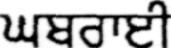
ਘਬਰਾਈ
